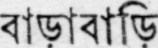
বাড়াবাড়ি
